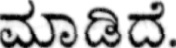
ಮಾಡಿದೆ.
